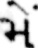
મેં
